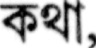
কথা,
